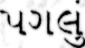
પગલું
